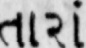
તારાં
